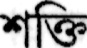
শক্তি
